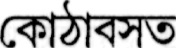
কোঠাবসত
